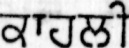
ਕਾਹਲੀ
